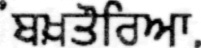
'ਬਖ਼ਤੌਰਿਆ,
